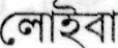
লোইবা
